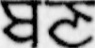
ਬਣ
